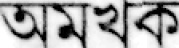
অমখক
